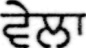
ਵੇਲਾ
